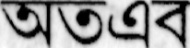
অতএব
